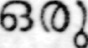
ഒരു
